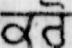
ਕਰੋ
